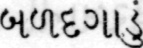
બળદગાડું
